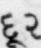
દૂર
